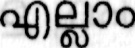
എല്ലാം
